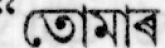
"তোমাৰ
